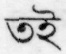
তই
